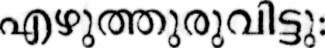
എഴുത്തുരുവിട്ടു:
